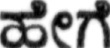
ಹೇಗೆ
